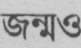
জন্মও
